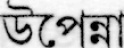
উপেন্না
